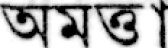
অমত্তা
